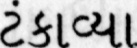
ટંકાવ્યા
